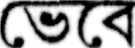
ভেবে
